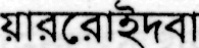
য়াররোইদবা
